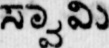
ಸ್ವಾಮಿ
